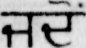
ਜਦੋਂ
